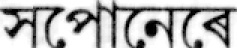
সপোনেৰে
